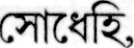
সোধেহি,
